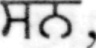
ਸਨ,
